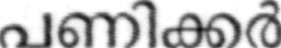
പണിക്കര്‍
